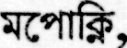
মপোক্নি,
